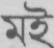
মই
